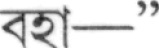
বহা-"
